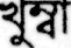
খুম্বা
